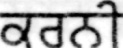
ਕਰਨੀ
